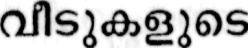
വീടുകളുടെ
